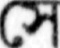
সে
